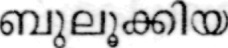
ബുലൂക്കിയ
